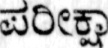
ಪರೀಕ್ಷಾ
